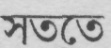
সততে
